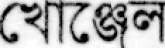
খোঞ্জেল
